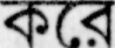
করে
